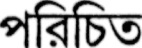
পরিচিত
